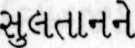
સુલતાનને
